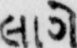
લાગે
